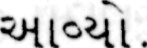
આવ્યો.
